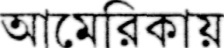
আমেরিকায়
